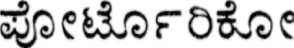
ಪೋರ್ಟೊರಿಕೋ
